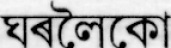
ঘৰলৈকো
